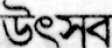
উৎসব
